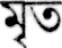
মৃত
